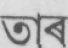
তাৰ
